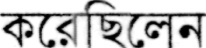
করেছিলেন
